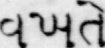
વખતે
